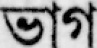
ভাগ
